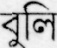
বুলি
